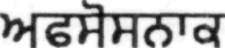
ਅਫਸੋਸਨਾਕ
